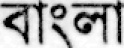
বাংলা
